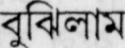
বুঝিলাম
